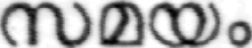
സമയം
